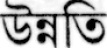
উন্নতি
